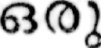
ഒരു
